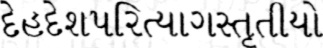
દેહદેશપરિત્યાગસ્તૃતીયો
